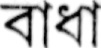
বাধা
